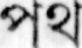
পথ
